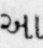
આ
